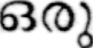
ഒരു
